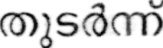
തുടര്‍ന്ന്
